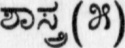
ಶಾಸ್ತ್ರ(೫)
